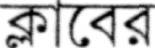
ক্লাবের
